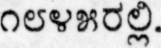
೧೮೪೫ರಲ್ಲಿ.
